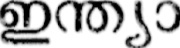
ഇന്ത്യാ
